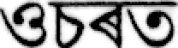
ওচৰত
